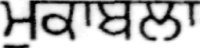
ਮੁਕਾਬਲਾ
